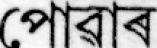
পোৱাৰ
